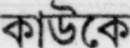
কাউকে
